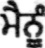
ਮੈਨੂੰ
